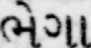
ભેગા
